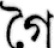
গৈ
